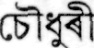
চৌধুৰী
